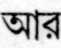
আর
